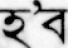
হ'ব
